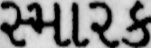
સ્મારક
